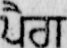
ਪੈਗ
